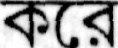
করে
